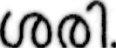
ശരി.
